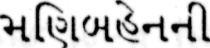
મણિબહેનની
